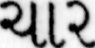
ચાર
